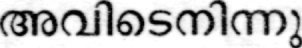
അവിടെനിന്നു
